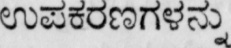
ಉಪಕರಣಗಳನ್ನು
